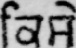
ਕਿਸੇ
